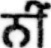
ਨੀਂ
